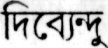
দিব্যেন্দু
